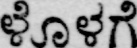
ಳೊಳಗೆ
